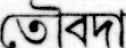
তৌবদা
